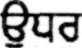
ਉਧਰ
